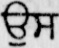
ਉਸ
